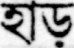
হাড়
